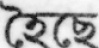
হৈছে
